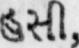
હસી,
